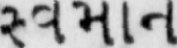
સ્વમાન
